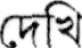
দেখি
